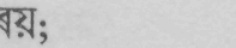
ৰয়;
